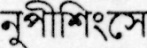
নুপীশিংসে
